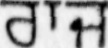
ਰਾਜ
